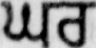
ਘਰ
